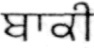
ਬਾਕੀ
